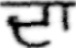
ਦਾ
